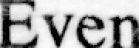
Even
